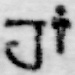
ਹਾਂ
